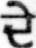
ਦੇ
